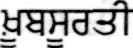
ਖ਼ੂਬਸੂਰਤੀ
